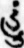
હું
